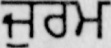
ਜੁਰਮ
